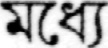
মধ্যে
